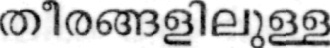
തീരങ്ങളിലുള്ള
